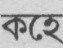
কহে
